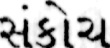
સંકોચ
